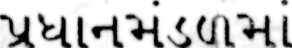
પ્રધાનમંડળમાં
